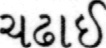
ચઢાઈ
